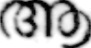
ആ
